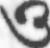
ও
